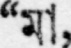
‘‘মা,
